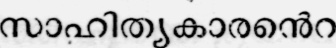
സാഹിത്യകാരന്റെ
